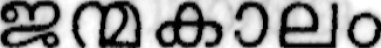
ജന്മകാലം
